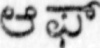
ಆಫ್
